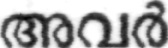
അവര്‍
